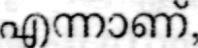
എന്നാണ്,
